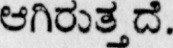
ಆಗಿರುತ್ತದೆ.
